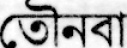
তৌনবা
